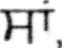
ਸਾਂ,
